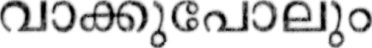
വാക്കുപോലും
